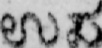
ಉಪ
